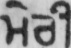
ਮੇਰੀ
